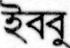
ইববু
